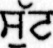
ਸੁੱਟ
